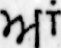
ਆਂ
